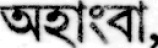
অহাংবা,
